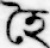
হৈ
